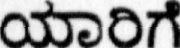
ಯಾರಿಗೆ
